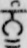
ਨੂੰ
